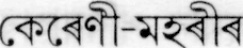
কেৰেণী-মহৰীৰ
